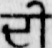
ਦੀ
